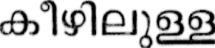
കീഴിലുള്ള
